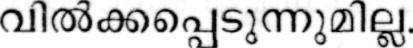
വില്‍ക്കപ്പെടുന്നുമില്ല.
